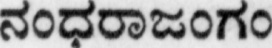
ನಂಧರಾಜಂಗಂ
